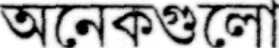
অনেকগুলো
